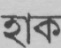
হাক
